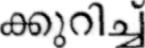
ക്കുറിച്ച്
